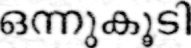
ഒന്നുകൂടി
